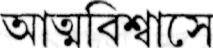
আত্মবিশ্বাসে
